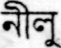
নীলু
